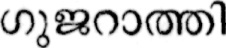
ഗുജറാത്തി
